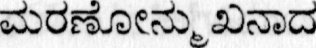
ಮರಣೋನ್ಮುಖನಾದ
